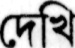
দেখি
